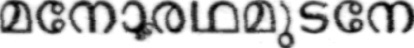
മനോരഥമുടനേ
